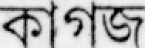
কাগজ
